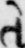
તે
